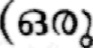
(ഒരു
